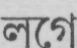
লগে
